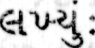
લખ્યું:
